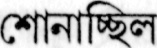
শোনাচ্ছিল
